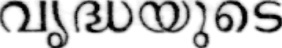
വൃദ്ധയുടെ
